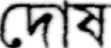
দোষ
